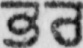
ਭਰ
